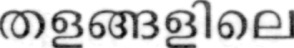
തളങ്ങളിലെ
